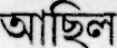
আছিল
